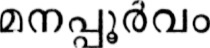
മനപ്പൂര്‍വം
